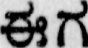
ಈಗ
